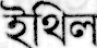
ইথিল
